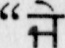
''ਜੇ
